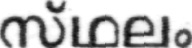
സ്ഥലം
